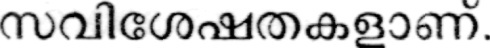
സവിശേഷതകളാണ്.
